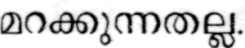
മറക്കുന്നതല്ല.
